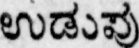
ಉಡುಪು
